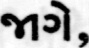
જાગે,
